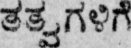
ತತ್ವಗಳಿಗೆ
